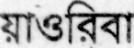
য়াওরিবা
